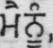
ਮੈਨੂੰ,
